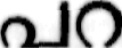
പറ
